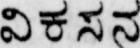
ವಿಕಸನ
